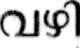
വഴി
